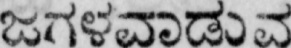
ಜಗಳವಾಡುವ
